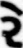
રે
